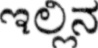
ಇಲ್ಲಿನ
